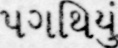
પગથિયું
